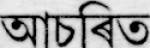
আচৰিত
